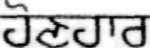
ਹੋਣਹਾਰ
